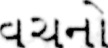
વચનો
